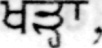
ਖੜ੍ਹਾ,
